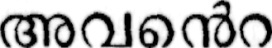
അവന്റെ
